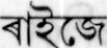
ৰাইজে
